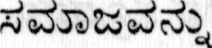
ಸಮಾಜವನ್ನು
